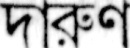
দারুণ
